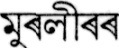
মুৰলীৰৰ
